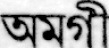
অমগী
